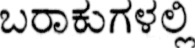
ಬರಾಕುಗಳಲ್ಲಿ
